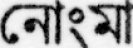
নোংমা
